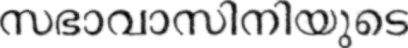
സഭാവാസിനിയുടെ
